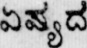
ಏಷ್ಯದ
